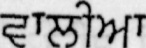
ਵਾਲੀਆ
